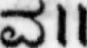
ವ||
